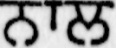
ਨਾਲ
